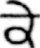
ਕੇ
